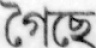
গৈছে
